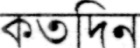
কতদিন
